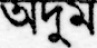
অদুম
